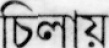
চিলায়
